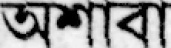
অশাবা
